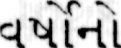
વર્ષોનો
